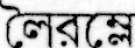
লৈরম্লে
